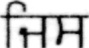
ਜਿਸ
